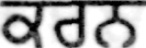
ਕਰਨ
